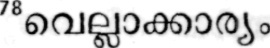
78വെല്ലാക്കാര്യം
